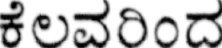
ಕೆಲವರಿಂದ
